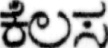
ಕೆಲಸ
